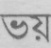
ভয়
